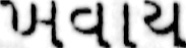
ખવાય
